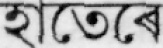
হাতেৰে
